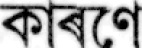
কাৰণে
